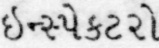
ઇન્સ્પેકટરો
